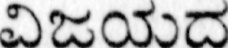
ವಿಜಯದ
